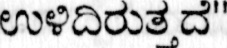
ಉಳಿದಿರುತ್ತದೆ”
